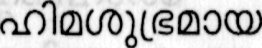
ഹിമശുഭ്രമായ
